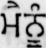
ਮੈਨੂੰ
